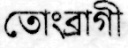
তোংব্রাগী
